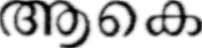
ആകെ
